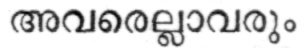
അവരെല്ലാവരും
